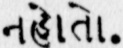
નહોતો.
